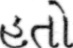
હતો
